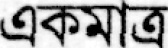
একমাত্র
